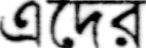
এদের
